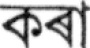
কৰা
